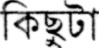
কিছুটা
